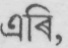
এৰি,
